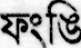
ফংঙি
